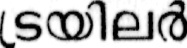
ട്രയിലര്‍
